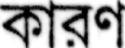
কারণ
